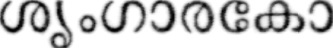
ശ്യംഗാരകോ
